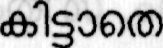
കിട്ടാതെ
